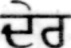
ਦੇਰ
